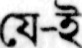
যে-ই
